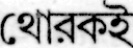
থোরকই
